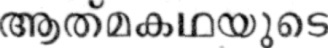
ആത്മകഥയുടെ
